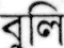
বুলি
